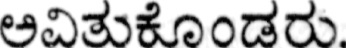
ಅವಿತುಕೊಂಡರು.
